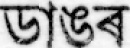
ডাঙৰ
